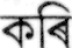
কৰি
